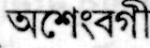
অশেংবগী
